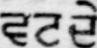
ਵਟਦੇ
